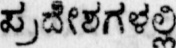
ಪ್ರದೇಶಗಳಲ್ಲಿ
